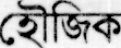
হৌজিক
